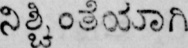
ನಿಶ್ಚಿಂತೆಯಾಗಿ
